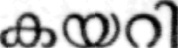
കയറി
